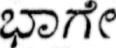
ಭಾಗೇ
